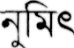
নুমিৎ
